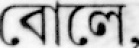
বোলে,
